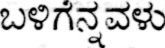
ಬಳಿಗೆನ್ನವಳು
